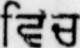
ਵਿਚ
